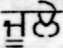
ਜੂਲੇ
